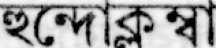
হুন্দোক্লম্বা
